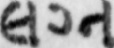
લગ્ન
